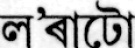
ল'ৰাটো
